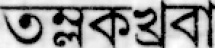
তম্লকখ্রবা
